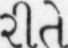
રીતે
